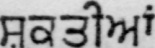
ਸ਼ਕਤੀਆਂ
